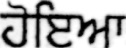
ਹੋਇਆ
